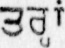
ਤਰ੍ਹਾਂ
